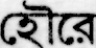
হৌরে
